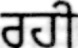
ਰਹੀ
